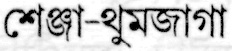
শেঞ্জা-থুমজাগা
